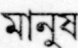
মানুষ
